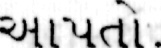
આપતો.
